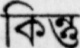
কিন্তু
